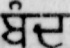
ਬੰਦ
